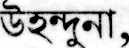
উহন্দুনা,
